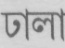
ঢালা
